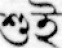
শুই
